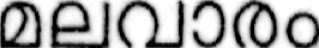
മലവാരം
